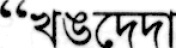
“খঙদেদা
